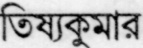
তিষ্যকুমার
